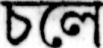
চলে
